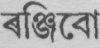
ৰঞ্জিবো
